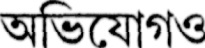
অভিযোগও
